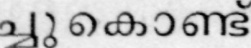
ച്ചുകൊണ്ട്
